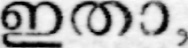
ഇതാ,
